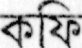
কফি
